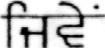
ਜਿਵੇਂ
